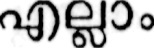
എല്ലാം
